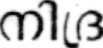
നിദ്ര
